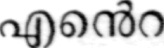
എന്റെ
